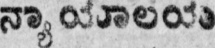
ನ್ಯಾಯಾಲಯ
